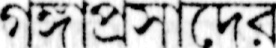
গঙ্গাপ্রসাদের
